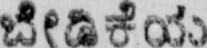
ಬೇಡಿಕೆಯ
